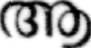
ആ
